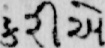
કરીએ
